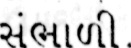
સંભાળી.
